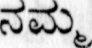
ನಮ್ಮ
